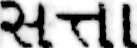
સત્તા
